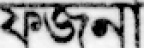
ফজনা
